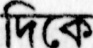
দিকে
